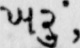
ખરું,
